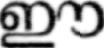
ഈ
